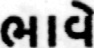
ભાવે
